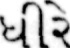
ધીરે
